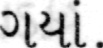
ગયાં.
